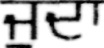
ਜੁਦਾ
